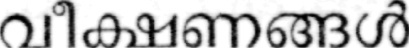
വീക്ഷണങ്ങള്‍
